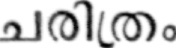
ചരിത്രം
